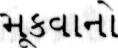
મૂકવાનો
